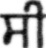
ਸੀ
